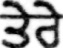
ਤੇਰੇ
